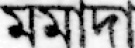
মমাদা
